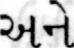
અને
